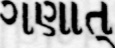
ગણાત્
